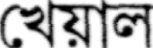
খেয়াল
